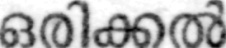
ഒരിക്കല്‍
